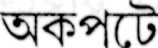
অকপটে
